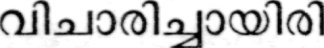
വിചാരിച്ചായിരി
